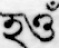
হওঁ
